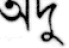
অদু
